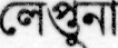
লেপ্তুনা
